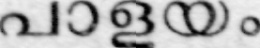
പാളയം
